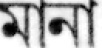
মানা
